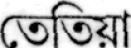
তেতিয়া
